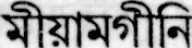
মীয়ামগীনি
